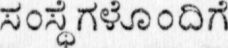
ಸಂಸ್ಥೆಗಳೊಂದಿಗೆ
